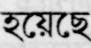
হয়েছে
